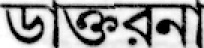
ডাক্তরনা
